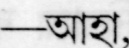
–আহা,
